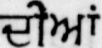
ਦੀਆਂ
